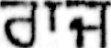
ਰਾਜ
